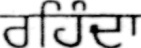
ਰਹਿੰਦਾ
